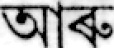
আৰু
